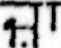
ਜ਼ਾ
